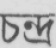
চন্দ্ৰ
